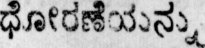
ಧೋರಣೆಯನ್ನು
